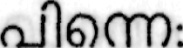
പിന്നെ:
